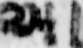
આ
